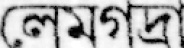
লেমগদ্রা
